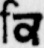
ਕਿ
